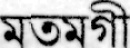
মতমগী
